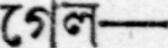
গেল—
